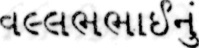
વલ્લભભાઈનું
